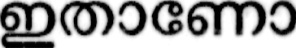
ഇതാണോ
